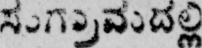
ಸುಗ್ರಾಮದಲ್ಲಿ
